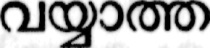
വയ്യാത്ത
